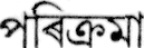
পৰিক্রমা
